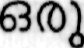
ഒരു
